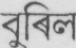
বুৰিল
